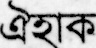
ঐহাক
